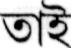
তাই
